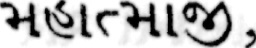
મહાત્માજી,
